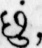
છું,
